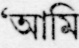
‘আমি
